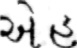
નિજ
